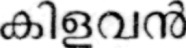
കിളവന്‍
